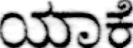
ಯಾಕೆ
